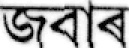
জবাৰ
